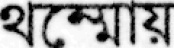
থম্মোয়
